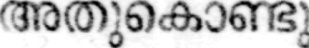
അതുകൊണ്ടു
